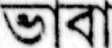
ভাবা
